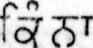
ਕਿੰਨਾ
